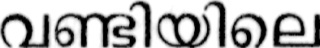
വണ്ടിയിലെ
